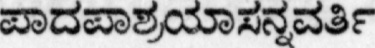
ಪಾದಪಾಶ್ರಯಾಸನ್ನವರ್ತಿ
